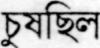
চুষছিল
